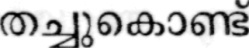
തച്ചുകൊണ്ട്
